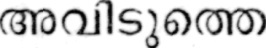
അവിടുത്തെ
